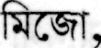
মিজো,
